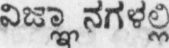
ವಿಜ್ಞಾನಗಳಲ್ಲಿ
